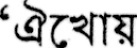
‘ঐখোয়
